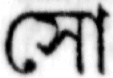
সো
